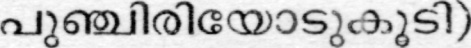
പുഞ്ചിരിയോടുകൂടി)
